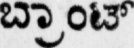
ಬ್ರಾಂಟ್
